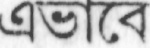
এভাবে
